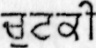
ਚੁਟਕੀ
